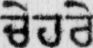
ਚੇਹਰੇ
